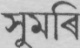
সুমৰি
